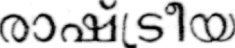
രാഷ്ട്രീയ
